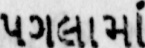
પગલમાં
